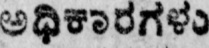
ಅಧಿಕಾರಗಳು
